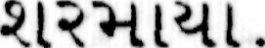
શરમાયા.
